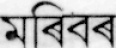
মৰিবৰ
